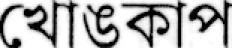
খোঙকাপ
